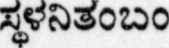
ಸ್ಥಳನಿತಂಬಂ
